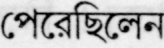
পেরেছিলেন
